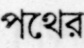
পথের
